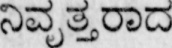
ನಿವೃತ್ತರಾದ
